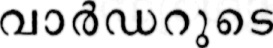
വാര്‍ഡറുടെ
